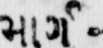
માર્ગ-
